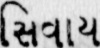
સિવાય
